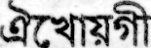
ঐখোয়গী
